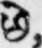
છે,
